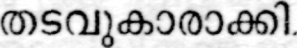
തടവുകാരാക്കി.
